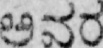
ಅವರ
